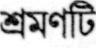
শ্রমণটি
